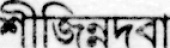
শীজিন্নদবা
